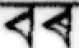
বৰ
